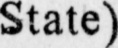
State)
